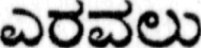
ಎರವಲು
